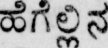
ಹೆಗೆಲ್ಲಿನ
